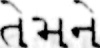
તેમને
